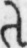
તે
